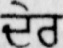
ਦੇਰ
